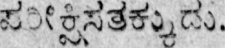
ಪರೀಕ್ಷಿಸತಕ್ಕುದು.
